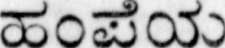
ಹಂಪೆಯ
